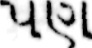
પણ
